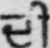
ਦੀ
